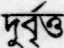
দুর্বৃত্ত
